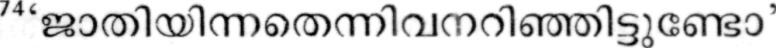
74'ജാതിയിന്നതെന്നിവനറിഞ്ഞിട്ടുണ്ടോ'
